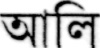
আলি
